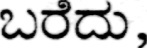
ಬರೆದು,
